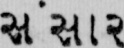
સંસાર
